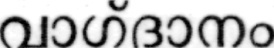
വാഗ്ദാനം
